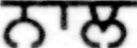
ਨਾਲ
